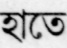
হাতে
